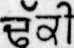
ਢੱਕੀ
